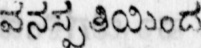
ವನಸ್ಪತಿಯಿಂದ
